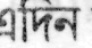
এদিন
